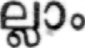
ല്ലാം
